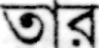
তার
